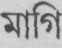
মাগি
